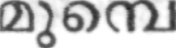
മുമ്പെ
